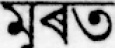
মূৰত
